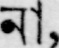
না,
